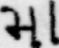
મા
